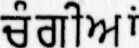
ਚੰਗੀਆਂ
